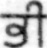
ਭੀ
